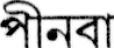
পীনবা
